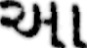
આ
